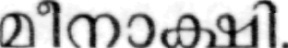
മീനാക്ഷി.
